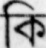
কি
